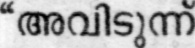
“അവിടുന്ന്
